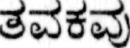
ತವಕವು
